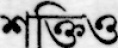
শক্তিও
